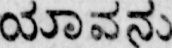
ಯಾವನು
